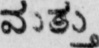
ಮತ್ತು
